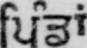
ਪਿੰਡਾਂ
